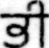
ਭੀ
